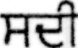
ਸਦੀ
